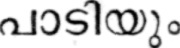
പാടിയും
